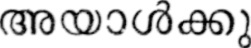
അയാള്‍ക്കു
